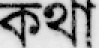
কথা
